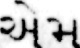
એમ
